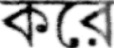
করে
